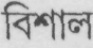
বিশাল
